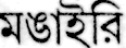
মঙাইরি
